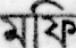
মফি
